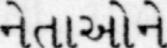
નેતાઓને
